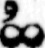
ಹಿ
